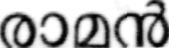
രാമന്‍
